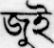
জুই
